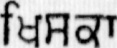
ਖਿਸਕਾ
